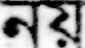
নয়
